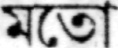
মতো
